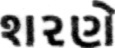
શરણે
